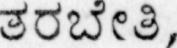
ತರಬೇತಿ,
